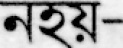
নহয়-
